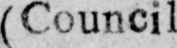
(Council
